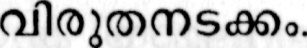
വിരുതനടക്കം.
